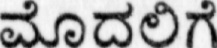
ಮೊದಲಿಗೆ
